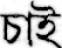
চাই
